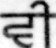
ਵੀ
